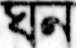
ঘন
